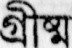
গ্রীষ্ম
